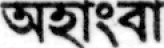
অহাংবা
